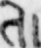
તો
